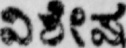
ವಿಶೇಷ
